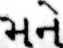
મને
